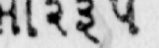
ભારરૂપ
